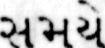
સમયે
